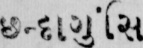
ઈન્દાગુંસિ
